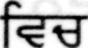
ਵਿਚ
